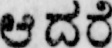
ಆದರೆ
